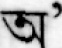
অ'
